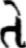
તે
